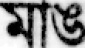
মাঙ
